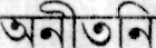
অনীতনি
